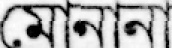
মোনানা
